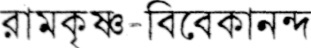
রামকৃষ্ণ-বিবেকানন্দ
